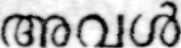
അവള്‍
